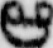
ಆ
